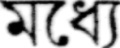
মধ্যে
